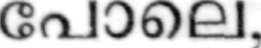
പോലെ,
